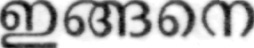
ഇങ്ങനെ
